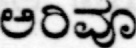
ಅರಿವೂ
